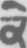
ਕੇ
